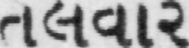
તલવાર
